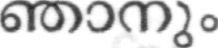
ഞാനും
